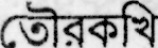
তৌরকখি
